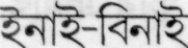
ইনাই-বিনাই
